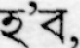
হ'ব,
